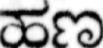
ಹಣ
